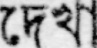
দেখা
